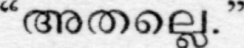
"അതല്ലെ."
